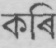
কৰি
